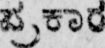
ಪ್ರಕಾರ
